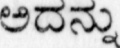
ಅದನ್ನು
